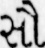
સૌ
